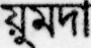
য়ুমদা
